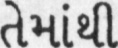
તેમાંથી
